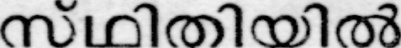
സ്ഥിതിയില്‍
